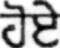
ਹੋਏ
